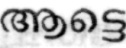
ആട്ടെ
